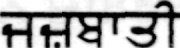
ਜਜ਼ਬਾਤੀ
